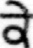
ਕੇ
